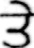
ਤੇ
